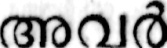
അവര്‍
